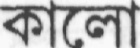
কালো
